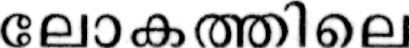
ലോകത്തിലെ
